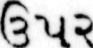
ઉપર
